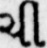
ચીં
